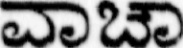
ವಾಚಾ
